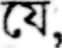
যে,
